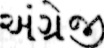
અંગ્રેજી
